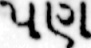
પણ
